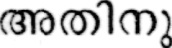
അതിനു
